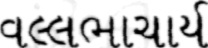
વલ્લભાચાર્ય
